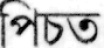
পিচত
